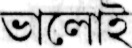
ভালোই
